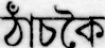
ঠাঁচকৈ
